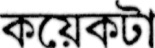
কয়েকটা
